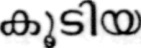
കൂടിയ
